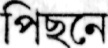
পিছনে
